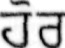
ਹੋਰ
